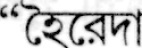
“হৈরেদা
